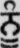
ਨੂੰ
